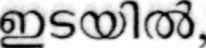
ഇടയില്‍,
